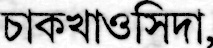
চাকখাওসিদা,
